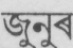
জুনুৰ
